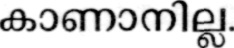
കാണാനില്ല.
